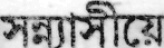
সন্ন্যাসীয়ে
